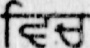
ਵਿਚ
